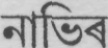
নাভিৰ
